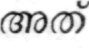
അത്
